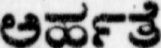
ಅರ್ಹತೆ
